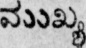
ಮುಖ್ಯ
